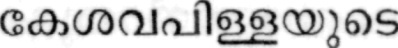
കേശവപിള്ളയുടെ
